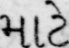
માટે
